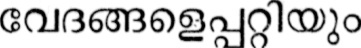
വേദങ്ങളെപ്പറ്റിയും
